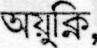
অয়ুক্নি,
